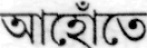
আহোঁতে
